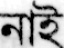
নাই
